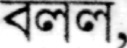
বলল,
